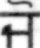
ਜੋ
